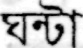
ঘন্টা
